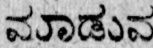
ಮಾಡುವ
